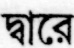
দ্বারে
